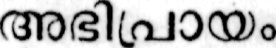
അഭിപ്രായം
